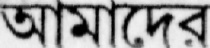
আমাদের
